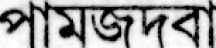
পামজদবা
